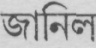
জানিল
